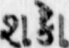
શકો
